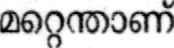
മറ്റെന്താണ്
